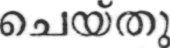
ചെയ്തു
